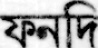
ফনদি
